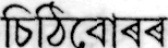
চিঠিবোৰৰ
